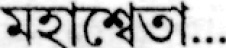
মহাশ্বেতা...
